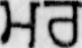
ਮਰ
